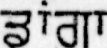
ਡਾਂਗਾ
